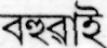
বহুৱাই
